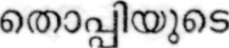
തൊപ്പിയുടെ
